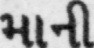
માની
